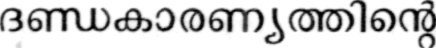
ദണ്ഡകാരണ്യത്തിന്റെ
